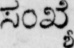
ಸಂಖ್ಯೆ
